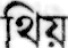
থিয়
